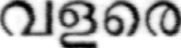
വളരെ
